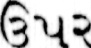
ઉપર
